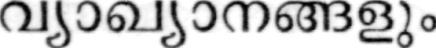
വ്യാഖ്യാനങ്ങളും
